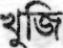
খুজি
